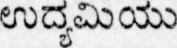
ಉದ್ಯಮಿಯು
